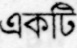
একটি
